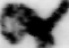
જ
